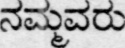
ನಮ್ಮವರು
